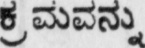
ಕ್ರಮವನ್ನು
